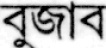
বুজাব
